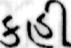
કહી
